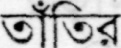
তাঁতির
